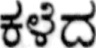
ಕಳೆದ
